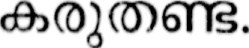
കരുതണ്ട.
